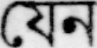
যেন
